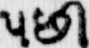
પછી
